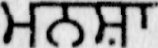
ਮਨਸ਼ਾ
